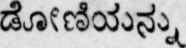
ಡೋಣಿಯನ್ನು
